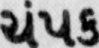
ચંપક
